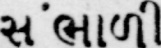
સંભાળી
